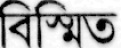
বিস্মিত
